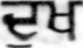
ਦੁਖ
